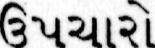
ઉપચારો
